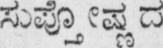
ಸುಪ್ತೋಷ್ಣದ
